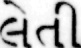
લેતી
